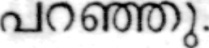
പറഞ്ഞു.
